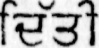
ਦਿੱਤੀ
